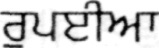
ਰੁਪਈਆ
